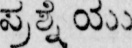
ಪ್ರಶ್ನೆಯು
